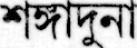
শঙ্গাদুনা
